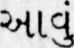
આવું
